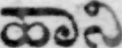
ಹಾನಿ
